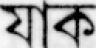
যাক
